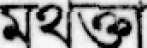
মথক্তা
